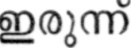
ഇരുന്ന്
